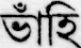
ভাঁহি
